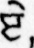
ਏ,
